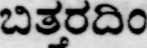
ಬಿತ್ತರದಿಂ
